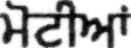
ਮੋਟੀਆਂ
